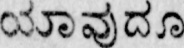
ಯಾವುದೂ
